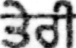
ਤੇਰੀ
